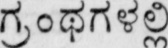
ಗ್ರಂಥಗಳಲ್ಲಿ
